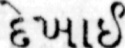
દેખાઈ
